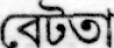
বেটতা
